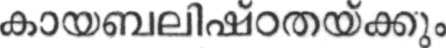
കായബലിഷ്ഠതയ്ക്കും
